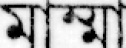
মাম্মা
